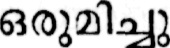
ഒരുമിച്ചു
